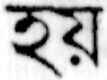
হয়
